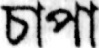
চাপা
